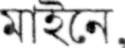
মাইনে,
